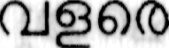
വളരെ
